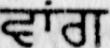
ਵਾਂਗ
